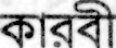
কারবী
